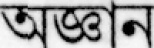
অজ্ঞান
